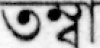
তম্বা
